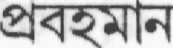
প্রবহমান
